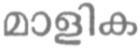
മാളിക
